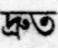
দ্রুত
